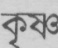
কৃষ্ণ
